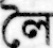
লৈ
